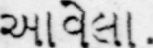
આવેલા.
